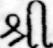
શ્રી
